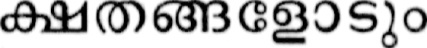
ക്ഷതങ്ങളോടും
